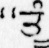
''ਤੂੰ
